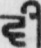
ਵੀ
